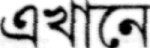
এখানে
